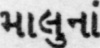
માલુનાં
